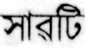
সাৱটি
